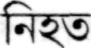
নিহত
